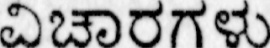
ವಿಚಾರಗಳು
